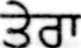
ਤੇਰਾ
